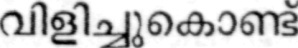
വിളിച്ചുകൊണ്ട്
